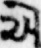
એ
